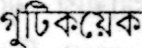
গুটিকয়েক
